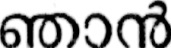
ഞാന്‍
